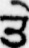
ਤੇ
